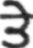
ਤੇ
